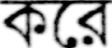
করে
